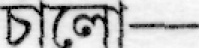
চালো-
